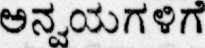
ಅನ್ವಯಗಳಿಗೆ
